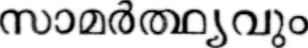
സാമര്‍ത്ഥ്യവും
